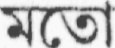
মতো
